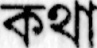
কথা
